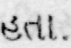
હતા.
